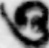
ও
